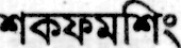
শকফমশিং
